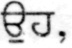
ਉਹ,
